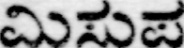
ಮಿಸುಪ
